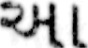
આ
